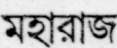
মহারাজ
